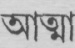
আত্মা
